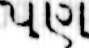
પણ
